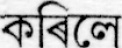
কৰিলে
